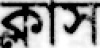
ক্লাস
